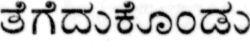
ತೆಗೆದುಕೊಂಡು
